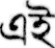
এই
